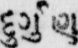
દુર્ગુણ
